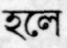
হলে
